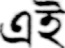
এই
